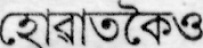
হোৱাতকৈও
